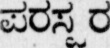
ಪರಸ್ಪರ
